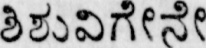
ಶಿಶುವಿಗೇನೇ
